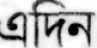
এদিন
